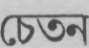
চেতন
